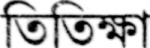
তিতিক্ষা
